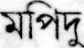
মপিদু
